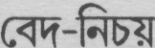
বেদ-নিচয়
